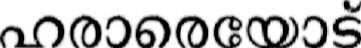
ഹരാരെയോട്
